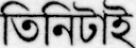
তিনিটাই
